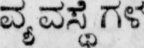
ವ್ಯವಸ್ಥೆಗಳ
